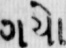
ગયો
